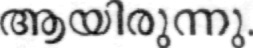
ആയിരുന്നു.
